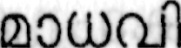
മാധവി
